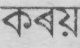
কৰয়
